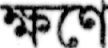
ক্ষণে
